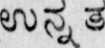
ಉನ್ನತ
